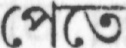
পেতে
